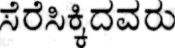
ಸೆರೆಸಿಕ್ಕಿದವರು
